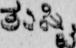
ತುಷ್ಟಿ
